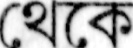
থেকে
